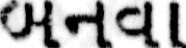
બનવા
